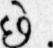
છે.
